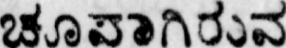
ಚೂಪಾಗಿರುವ
